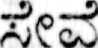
ಸೇವೆ
